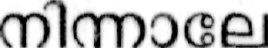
നിന്നാലേ
